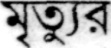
মৃত্যুর
